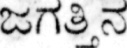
ಜಗತ್ತಿನ
